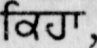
ਕਿਹਾ,
